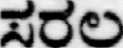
ಸರಲ
